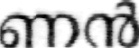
ണന്‍
